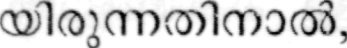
യിരുന്നതിനാല്‍,
